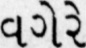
વગેરે
